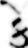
કે
